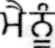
ਮੈਨੂੰ
